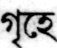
গৃহে
